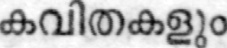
കവിതകളും
